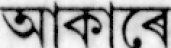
আকাৰে
